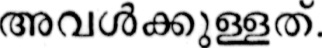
അവള്‍ക്കുള്ളത്.
